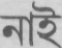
নাই
